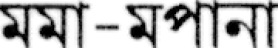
মমা-মপানা
